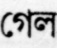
গেল
